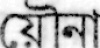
য়ৌনা
